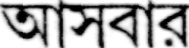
আসবার
